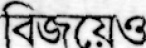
বিজয়েও
